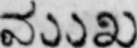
ಮುಖ
